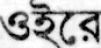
ওইরে
